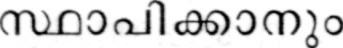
സ്ഥാപിക്കാനും
